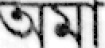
অমা
